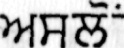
ਅਸਲੋਂ
